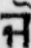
ਜੋ
